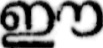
ഈ
